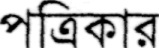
পত্রিকার
